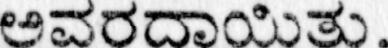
ಅವರದಾಯಿತು.
